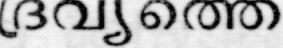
ദ്രവ്യത്തെ
